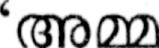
‘അമ്മ
